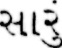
સારું
